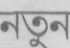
নতুন
